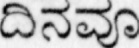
ದಿನವೂ
